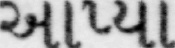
આપ્યા
